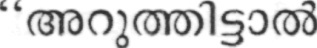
"അറുത്തിട്ടാല്‍
